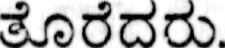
ತೊರೆದರು.
